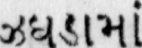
ઝઘડામાં
